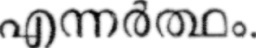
എന്നര്‍ത്ഥം.
